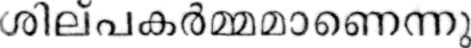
ശില്പകര്‍മ്മമാണെന്നു
